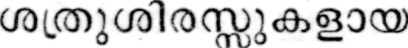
ശത്രുശിരസ്സുകളായ
